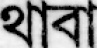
থাবা
